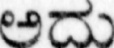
ಅದು
